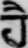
ਹੈ
